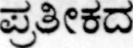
ಪ್ರತೀಕದ
